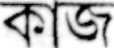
কাজ
